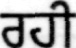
ਰਹੀ
